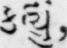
કહ્યું,
